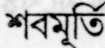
শবমূর্তি
